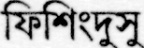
ফিশিংদুসু
